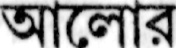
আলোর
